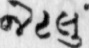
જેટલું
